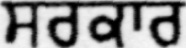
ਸਰਕਾਰ
